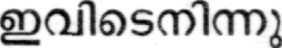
ഇവിടെനിന്നു
